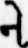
ને
